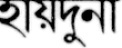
হায়দুনা
